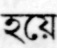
হয়ে
